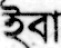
ইবা
